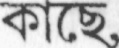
কাছে,
